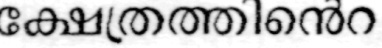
ക്ഷേത്രത്തിന്റെ
